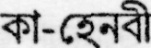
কা-হেনবী
